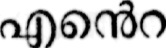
എന്റെ
